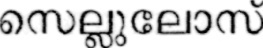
സെല്ലുലോസ്
